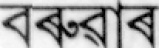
বৰুৱাৰ
